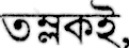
তম্লকই,
